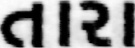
તારા
